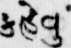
કહેવું
